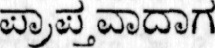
ಪ್ರಾಪ್ತವಾದಾಗ
